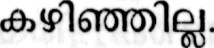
കഴിഞ്ഞില്ല.
